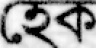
হেক
